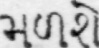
મળશે
